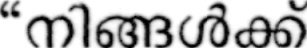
“നിങ്ങള്‍ക്ക്
